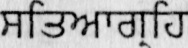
ਸਤਿਆਗ੍ਰਹਿ
